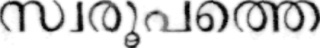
സ്വരൂപത്തെ
